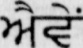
ਐਵੇਂ
